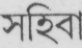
সহিবা
